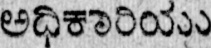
ಅಧಿಕಾರಿಯು
